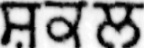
ਸ਼ਕਲ
